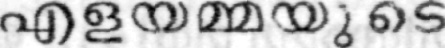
എളയമ്മയുടെ
